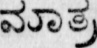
ಮಾತ್ರ
